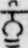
ਨੂੰ
